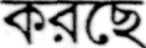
করছে
